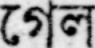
গেল
